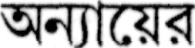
অন্যায়ের
